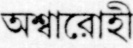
অশ্বারোহী
